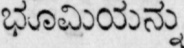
ಭೂಮಿಯನ್ನು
